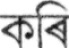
কৰি
